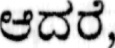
ಆದರೆ,
